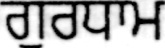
ਗੁਰਧਾਮ
